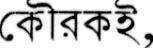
কৌরকই,
